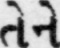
તેને
